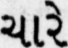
ચારે
